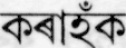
কৰাহঁক
